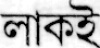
লাকই
